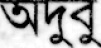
অদুবু
